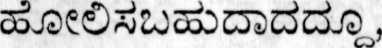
ಹೋಲಿಸಬಹುದಾದದ್ದೂ,
